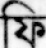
ফি
